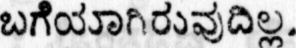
ಬಗೆಯಾಗಿರುವುದಿಲ್ಲ.
